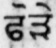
ਫੋੜੇ
